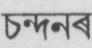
চন্দনৰ
